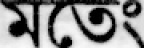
মতেং
